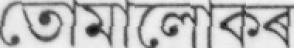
তোমালোকৰ
